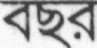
বছর
